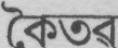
কৈতৱ
